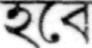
হবে
